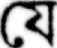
যে
